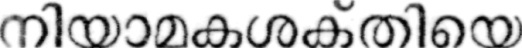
നിയാമകശക്തിയെ
